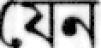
যেন
